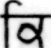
ਕਿ
